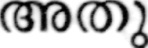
അതു
